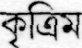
কৃত্রিম
